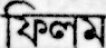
ফিলম
